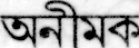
অনীমক
